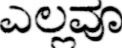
ಎಲ್ಲವೂ
